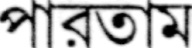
পারতাম
